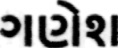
ગણેશ
